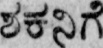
ಶಕನಿಗೆ
